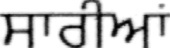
ਸਾਰੀਆਂ
